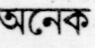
অনেক
